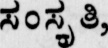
ಸಂಸ್ಕೃತಿ,
